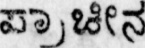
ಪ್ರಾಚೀನ
